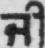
ਜੀ
